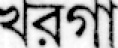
খরগা
